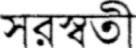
সরস্বতী
